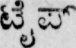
ಟೈಪ್
